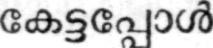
കേട്ടപ്പോള്‍
